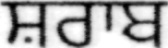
ਸ਼ਰਾਬ
